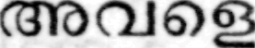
അവളെ
